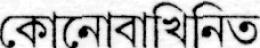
কোনোবাখিনিত
